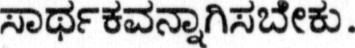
ಸಾರ್ಥಕವನ್ನಾಗಿಸಬೇಕು.
